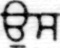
ਉਸ
